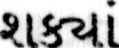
શક્યાં
